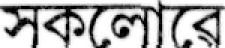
সকলোৱে
